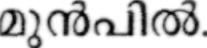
മുന്‍പില്‍.
